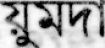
য়ুমদা
